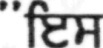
''ਇਸ
